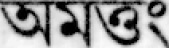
অমত্তং
